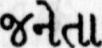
જનેતા
